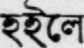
হইলে
